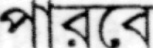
পারবে
